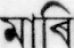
মাৰি
